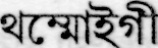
থম্মোইগী
